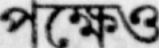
পক্ষেও
